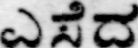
ಎಸೆದ
